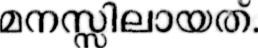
മനസ്സിലായത്.
